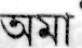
অমা
